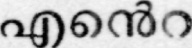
എന്റെ
